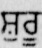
ਸ਼ੁਰੂ
